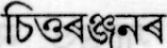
চিত্তৰঞ্জনৰ
